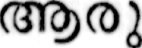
ആരു
